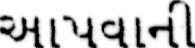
આપવાની
